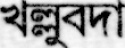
খল্লুবদা
